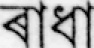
ৰাধা
